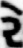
રે
